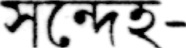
সন্দেহ-
